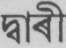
দ্বাৰী
